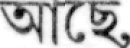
আছে,
